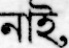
নাই,
